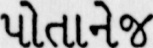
પોતાનેજ
